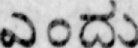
ಎಂದು
